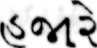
હજારે
